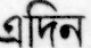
এদিন
